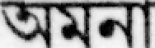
অমনা
